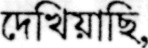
দেখিয়াছি,
